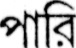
পারি
